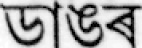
ডাঙৰ
